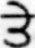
ਤੇ
